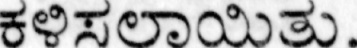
ಕಳಿಸಲಾಯಿತು.
